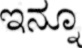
ಇನ್ನೂ
